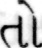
તો
